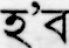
হ'ব
